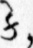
કે,
